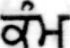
ਕੰਮ
